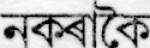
নকৰাকৈ
